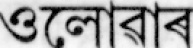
ওলোৱাৰ
